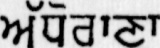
ਅੱਧੋਰਾਣਾ
